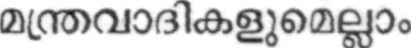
മന്ത്രവാദികളുമെല്ലാം
